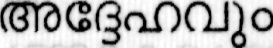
അദ്ദേഹവും
